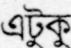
এটুকু
